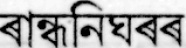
ৰান্ধনিঘৰৰ
